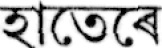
হাতেৰে
